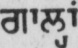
ਗਾਲ੍ਹਾਂ
